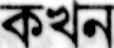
কখন
